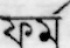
ফর্ম
